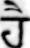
ਹੈ
